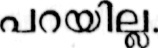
പറയില്ല.
